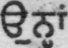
ਉਨ੍ਹਾਂ
